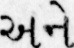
અને
